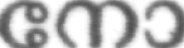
നോ
